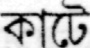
কাটে
